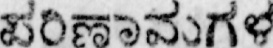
ಪರಿಣಾಮಗಳ
